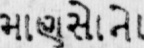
માણસોનો
